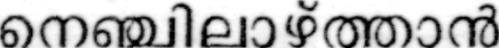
നെഞ്ചിലാഴ്ത്താന്‍
